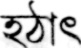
হঠাৎ
